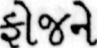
ફોજને
